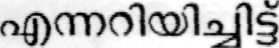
എന്നറിയിച്ചിട്ട്
